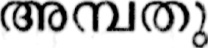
അമ്പതു
